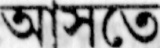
আসতে
